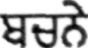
ਬਚਨੇ
